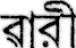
ৱারী
